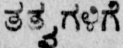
ತತ್ವಗಳಿಗೆ
